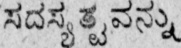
ಸದಸ್ಯತ್ವವನ್ನು
